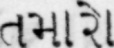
તમારો
